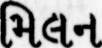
મિલન
